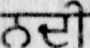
ਨਦੀ
